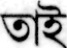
তাই
